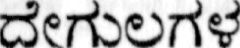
ದೇಗುಲಗಳ
